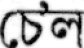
চে'ল
